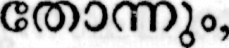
തോന്നും,
